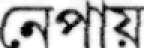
নেপায়
